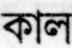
কাল
